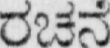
ರಚನೆ
